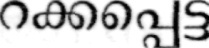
റക്കപ്പെട്ട
